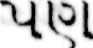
પણ
